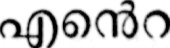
എന്റെ
